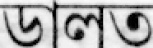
ডালত
